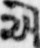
એ
